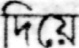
দিয়ে
